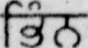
ਭਿੰਨ
